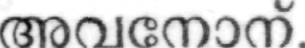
അവനോന്.
